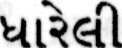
ધારેલી
